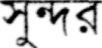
সুন্দর
